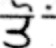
ਤੋਂ
